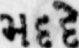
મદદે
